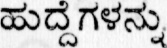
ಹುದ್ದೆಗಳನ್ನು
